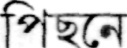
পিছনে
